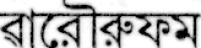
ৱারৌরুফম
